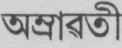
অম্ৰাৱতী
